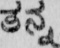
ತನ್ನ
